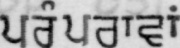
ਪਰੰਪਰਾਵਾਂ
